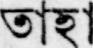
তাহা
